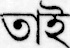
তাই
